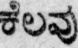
ಕೆಲವು
